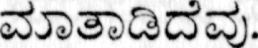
ಮಾತಾಡಿದೆವು.
